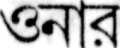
ওনার
